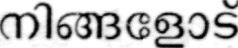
നിങ്ങളോട്
